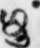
છું
